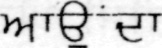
ਆਉਂਦਾ
